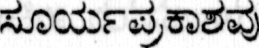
ಸೂರ್ಯಪ್ರಕಾಶವು
